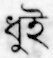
ধুই
